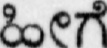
ಹೀಗೆ
